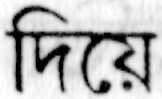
দিয়ে
